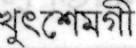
খুৎশেমগী
